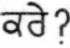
ਕਰੇ?
